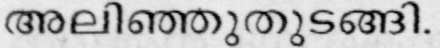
അലിഞ്ഞുതുടങ്ങി.
